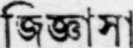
জিজ্ঞাসা
